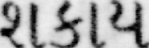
શકાય
